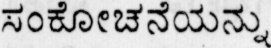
ಸಂಕೋಚನೆಯನ್ನು
